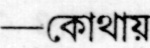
–কোথায়
